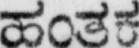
ಹಂತಕ
